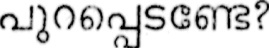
പുറപ്പെടണ്ടേ?
